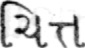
ચિત્ત
